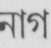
নাগ
